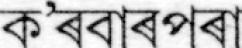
ক'ৰবাৰপৰা
